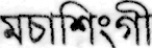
মচাশিংগী
